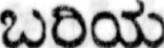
ಬರಿಯ
